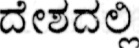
ದೇಶದಲ್ಲಿ
